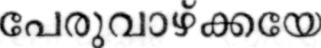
പേരുവാഴ്ക്കയേ
